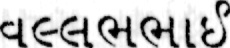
વલ્લભભાઈ
